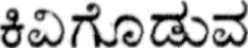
ಕಿವಿಗೊಡುವ
